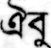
ঐবু
